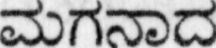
ಮಗನಾದ
